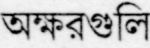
অক্ষরগুলি
